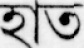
হাত
